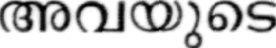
അവയുടെ
